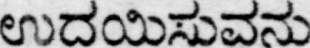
ಉದಯಿಸುವನು
